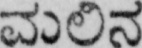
ಮಲಿನ
